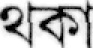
থকা
